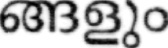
ങ്ങളും
